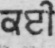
ਕਈ
